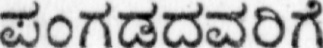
ಪಂಗಡದವರಿಗೆ
